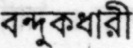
বন্দুকধারী
